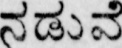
ನಡುವೆ
